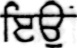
ਇਉਂ
